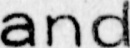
and
